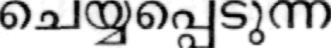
ചെയ്യപ്പെടുന്ന
